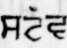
ਸਟੋਵ
